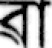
ৱা
